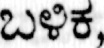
ಬಳಿಕ,
